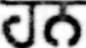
ਹਨ
